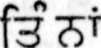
ਤਿੰਨਾਂ
